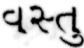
વસ્તુ
